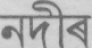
নদীৰ
